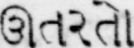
ઊતરતો
